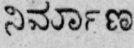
ನಿರ್ಮಾಣ
